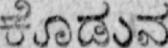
ಕೊಡುವ
